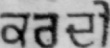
ਕਰਦੀ
